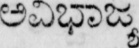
ಅವಿಭಾಜ್ಯ
